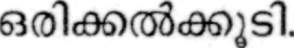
ഒരിക്കല്‍ക്കൂടി.
